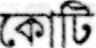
কোটি
